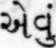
એવું
